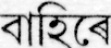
বাহিৰে
